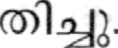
തിച്ചു.
